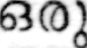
ഒരു
